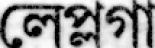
লেপ্লগা
